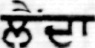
ਲੈਂਦਾ
